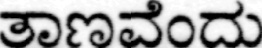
ತಾಣವೆಂದು
